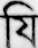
যি
